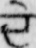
ਦੇ
